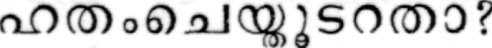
ഹതംചെയ്തൂടറതാ?
